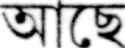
আছে
